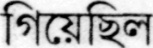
গিয়েছিল
